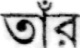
তাঁর
